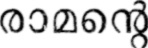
രാമന്റെ
